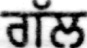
ਗੱਲ
